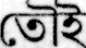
তৌই
